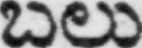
ಬಲು
